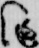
હિ
